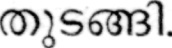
തുടങ്ങി.
